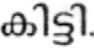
കിട്ടി.
